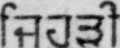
ਜਿਹੜੀ
